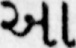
આ
